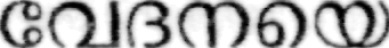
വേദനയെ
